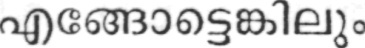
എങ്ങോട്ടെങ്കിലും
